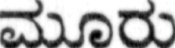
ಮೂರು
